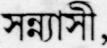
সন্ন্যাসী,
